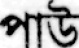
পাউ
